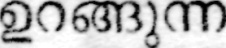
ഉറങ്ങുന്ന
